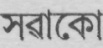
সৱাকো
